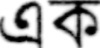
এক
